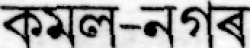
কমল-নগৰ
